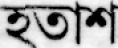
হতাশ
